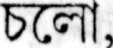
চলো,
